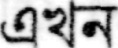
এখন
